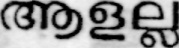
ആളല്ല
